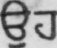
ਉਹ
